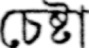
চেষ্টা
